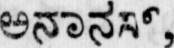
ಅನಾನಸ್,
